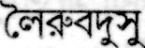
লৈরুবদুসু
